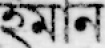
হমান
